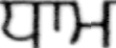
ਧਾਮ
